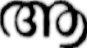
ആ
